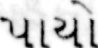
પાયો
